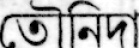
তৌনিদা
